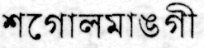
শগোলমাঙগী
